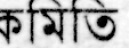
কমিতি
